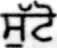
ਸੁੱਟੋ
